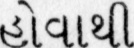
હોવાથી
